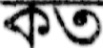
কত
